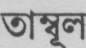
তাম্বূল
